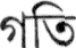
গতি
